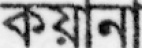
কয়ানা
